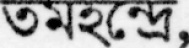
তমহন্দ্রে,
